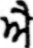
ਐ
